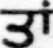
ਤਾਂ
